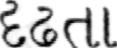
દૃઢતા
